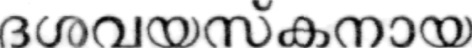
ദശവയസ്കനായ
